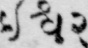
ઈશ્વર
